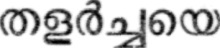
തളര്‍ച്ചയെ
